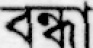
বন্ধা
